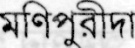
মণিপুরীদা
